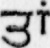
ਤਾਂ
